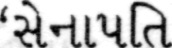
'સેનાપતિ
